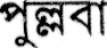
পুল্লবা
